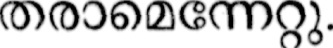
തരാമെന്നേറ്റു.
